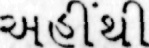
અહીંથી
